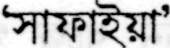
‘সাফাইয়া’
